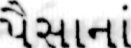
પૈસાનાં
